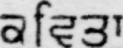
ਕਵਿਤਾ
